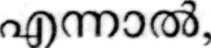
എന്നാല്‍,
